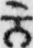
ਨੇ
